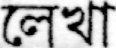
লেখা
